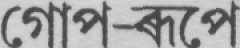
গোপ-ৰূপে
